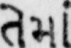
તેમાં
